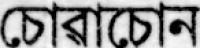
চোৱাচোন
